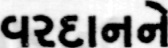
વરદાનને
